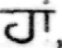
ਹਾਂ,
